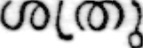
ശത്രു
